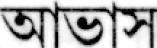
আভাস
